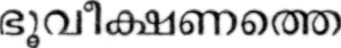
ഭൂവീക്ഷണത്തെ
